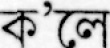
ক'লে
